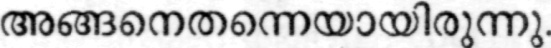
അങ്ങനെതന്നെയായിരുന്നു.
